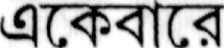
একেবারে
